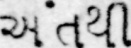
અંતથી
